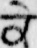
ਕੇ
